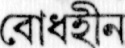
বোধহীন
